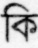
কি
